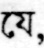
যে,
